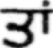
ਤਾਂ
